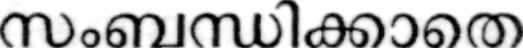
സംബന്ധിക്കാതെ
